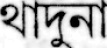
থাদুনা
